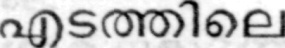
എടത്തിലെ
